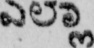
ಎಲ್ಲಾ
